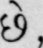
છે,
